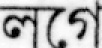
লগে
